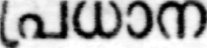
പ്രധാന
